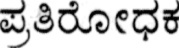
ಪ್ರತಿರೋಧಕ
